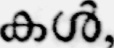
കള്‍,
